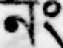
নং
